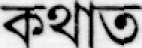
কথাত
